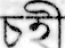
চহী
